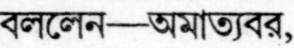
বললেন–অমাত্যবর,
